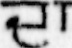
ਦਾ
